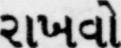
રાખવો
